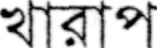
খারাপ
